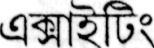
এক্সাইটিং
